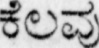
ಕೆಲವು
